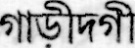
গাড়ীদগী
